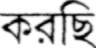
করছি
